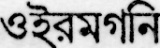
ওইরমগনি
